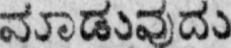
ಮಾಡುವುದು
